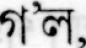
গ'ল,
